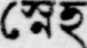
স্নেহ
